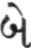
બે
